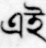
এই
